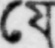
যে
